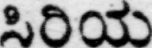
ಸಿರಿಯ
